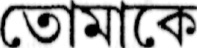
তোমাকে
